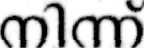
നിന്ന്
